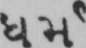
ધર્મ
